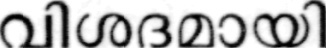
വിശദമായി
